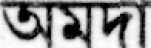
অমদা
